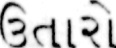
ઉતારો
